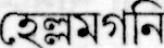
হেল্লমগনি
